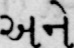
અને
